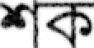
শক
